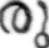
രു
